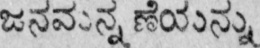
ಜನಮನ್ನಣೆಯನ್ನು
